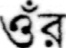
ওঁর
